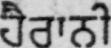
ਹੈਰਾਨੀ
